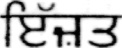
ਇੱਜ਼ਤ
